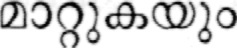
മാറ്റുകയും
